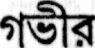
গভীর
